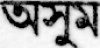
অসুম
